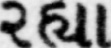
રહ્યા
